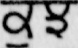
ਕੁਝ
